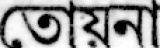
তোয়না
